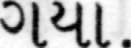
ગયા.
